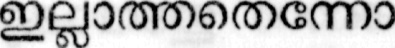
ഇല്ലാത്തതെന്നോ
